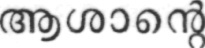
ആശാന്റെ
